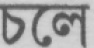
চলে
